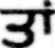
ਤਾਂ
